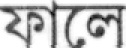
ফালে
